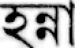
হন্না
